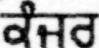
ਕੰਜਰ
